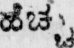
ಹೆಚ್ಚು
